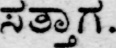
ಸತ್ತಾಗ.
